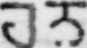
ਹਨ
